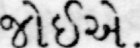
જોઈએ.
